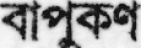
বাপুকণ
